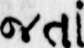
જતાં
